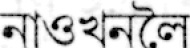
নাওখনলৈ
